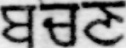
ਬਚਣ
